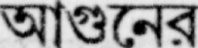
আগুনের
